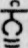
ਨੂੰ
